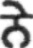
ਨੇ
